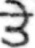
ਤੇ
